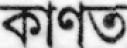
কাণত
